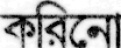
করিনো
